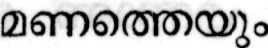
മണത്തെയും
